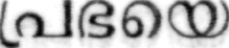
പ്രഭയെ
